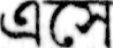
এসে
